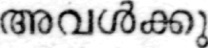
അവള്‍ക്കു
